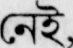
নেই,
